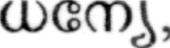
ധന്യേ,
